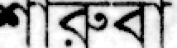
শারুবা
